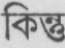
কিন্তু
